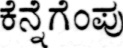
ಕೆನ್ನೆಗೆಂಪು
